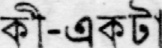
কী-একটা
